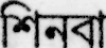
শিনবা
